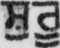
ਸ਼ੁਰੂ
